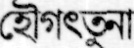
হৌগৎতুনা
